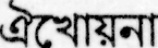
ঐখোয়না
